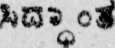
ಸಿದ್ದಾಂತ
